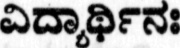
ವಿದ್ಯಾರ್ಥಿನಃ
